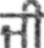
ਜੀ
